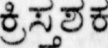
ಕ್ರಿಸ್ತಶಕ
